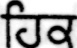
ਹਿਕ
